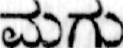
ಮಗು
